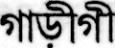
গাড়ীগী
